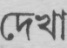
দেখা
